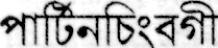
পার্টিনচিংবগী
